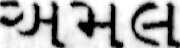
અમલ
